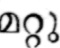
മറ്റു
